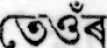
তেওঁৰ
